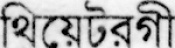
থিয়েটরগী
